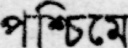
পশ্চিমে
